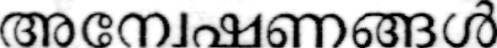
അന്വേഷണങ്ങള്‍
